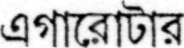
এগারোটার
